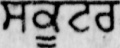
ਸਕੂਟਰ
